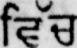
ਵਿੱਚ
